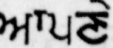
ਆਪਣੇ
